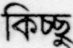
কিচ্ছু
